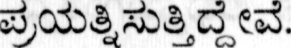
ಪ್ರಯತ್ನಿಸುತ್ತಿದ್ದೇವೆ.
